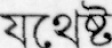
যথেষ্ট
